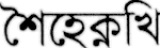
শৈহেক্নখি
